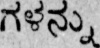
ಗಳನ್ನು
